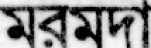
মরমদা
